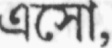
এসো,
